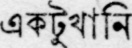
একটুখানি
